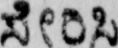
ಸೇರಿಸಿ
